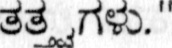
ತತ್ತ್ವಗಳು.”
